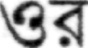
ওর
